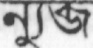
ন্যুব্জ
